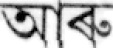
আৰু
